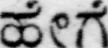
ಹೇಗೆ
